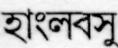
হাংলবসু
